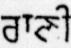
ਰਾਣੀ
